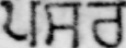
ਪਸਰ
